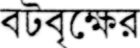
বটবৃক্ষের
